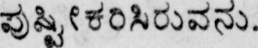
ಪುಷ್ಟೀಕರಿಸಿರುವನು.
